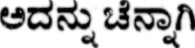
ಅದನ್ನುಚೆನ್ನಾಗಿ
